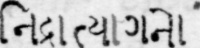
નિદ્રાત્યાગનો
